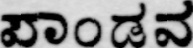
ಪಾಂಡವ
